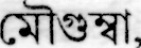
মৌগুম্বা,
